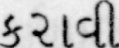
કરાવી
